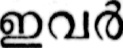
ഇവര്‍
